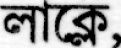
লাক্লে,
